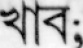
খাব;
